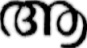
ആ
